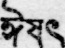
ঈষৎ
